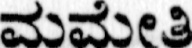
ಮಮೇತಿ
